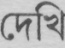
দেখি
